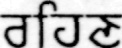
ਰਹਿਣ
